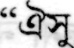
“ঐসু
